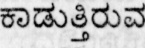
ಕಾಡುತ್ತಿರುವ
